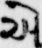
એ
